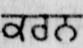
ਕਰਨ
